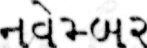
નવેમ્બર
